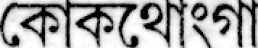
কোকথোংগা
